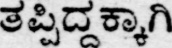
ತಪ್ಪಿದ್ದಕ್ಕಾಗಿ
